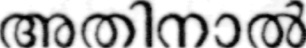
അതിനാല്‍
